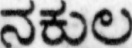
ನಕುಲ
